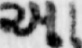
આ
